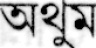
অথুম
